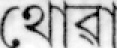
থোৱা
